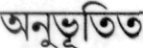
অনুভূতিত
